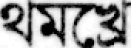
থমখ্রে
